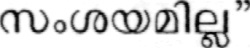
സംശയമില്ല”
